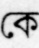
কে
